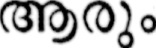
ആരും
